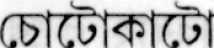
চোটোকাটো
